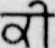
ਕੀ
